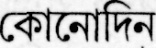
কোনোদিন
